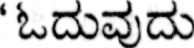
'ಓದುವುದು
